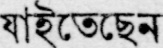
যাইতেছেন
